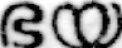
ഭയ
